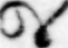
જ
